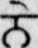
ਨੇ
